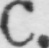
C.
